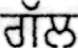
ਗੱਲ
